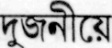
দুজনীয়ে
